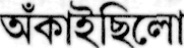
অঁকাইছিলো
